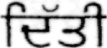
ਦਿੱਤੀ
